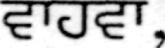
ਵਾਹਵਾ,
